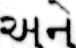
અને
